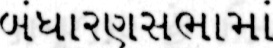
બંધારણસભામાં
